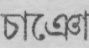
চাঞো
